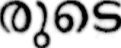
രുടെ
